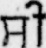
ਸੀ
